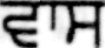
ਵਾਸ
